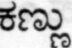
ಕಣ್ಣು
